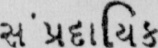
સંપ્રદાયિક
